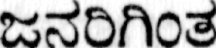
ಜನರಿಗಿಂತ
